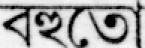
বহুতো
